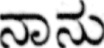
ನಾನು
